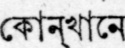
কোন্‌খানে
